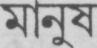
মানুষ
